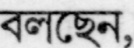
বলছেন,
